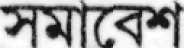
সমাবেশ
